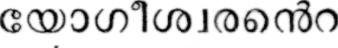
യോഗീശ്വരന്റെ
